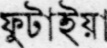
ফুটাইয়া
